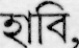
হাবি,
